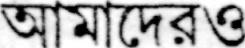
আমাদেরও
